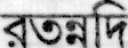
রতন্নদি
